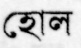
হোল
